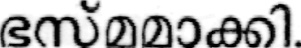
ഭസ്മമാക്കി.
